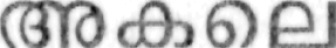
അകലെ
